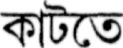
কাটতে
